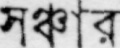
সঞ্চার
